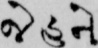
જેહને
